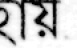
হায়
